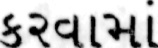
કરવામાં
